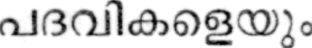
പദവികളെയും
